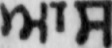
ਆਸ
